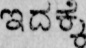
ಇದಕ್ಕೆ
